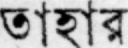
তাহার
